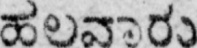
ಹಲವಾರು
